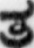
ತ
